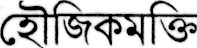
হৌজিকমক্তি
